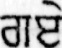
ਗਏ
